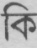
কি
